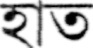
হাত
